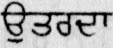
ਉਤਰਦਾ
